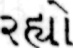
રહ્યો
